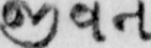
જીવન
